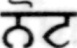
ਨੋਟ
